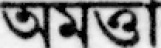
অমত্তা
